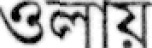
ওলায়
